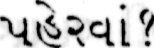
પહેરવાં?
